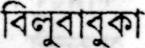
বিলুবাবুকা
